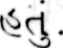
હતું.
